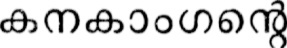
കനകാംഗന്റെ
